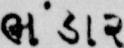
ભંડાર
